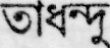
তাধন্দু
